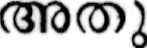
അതു
